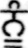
ਨੂੰ
